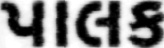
પાલક
